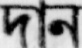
দান
